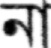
না
